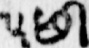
પછી
